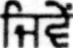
ਜਿਵੇਂ
